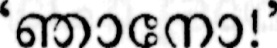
‘ഞാനോ!’
